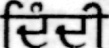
ਦਿੰਦੀ
